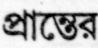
প্রান্তের
